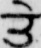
ਤੇ
